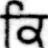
ਕਿ
